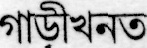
গাড়ীখনত
